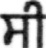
ਸੀ
